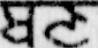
ਬਣ
